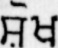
ਸ਼ੋਖ
